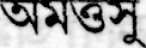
অমত্তসু
